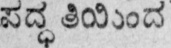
ಪದ್ಧತಿಯಿಂದ
